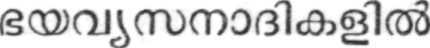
ഭയവ്യസനാദികളില്‍
